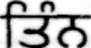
ਤਿੰਨ
